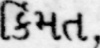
કિંમત,
